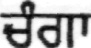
ਚੰਗਾ
